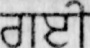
ਗਈ
